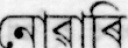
নোৱাৰি
